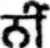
ਨੀਂ
